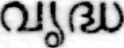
വൃദ്ധ
